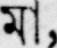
মা,
